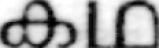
കഥ
